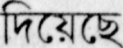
দিয়েছে
